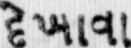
દેખાવા
